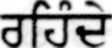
ਰਹਿੰਦੇ
